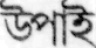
উপাই
